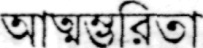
আত্মম্ভরিতা
